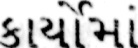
કાર્યોમાં
